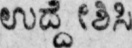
ಉದ್ದೇಶಿಸಿ
